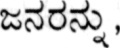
ಜನರನ್ನು,
